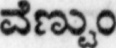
ವೆಣ್ಟುಂ
